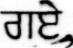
ਗਏ,
